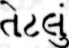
તેટલું
